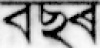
বছৰ
